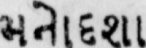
મનોદશા
